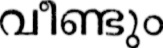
വീണ്ടും
